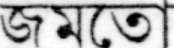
জমতো
